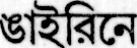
ঙাইরিনে
